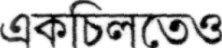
একচিলতেও
